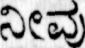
ನೀವು
